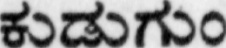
ಕುಡುಗುಂ
